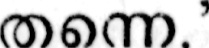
തന്നെ.’
